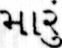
મારું
